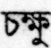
চক্ষু
